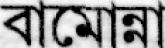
বামোন্না
